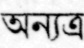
অন্যত্র
